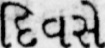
દિવસે
